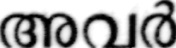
അവര്‍
